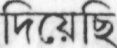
দিয়েছি
